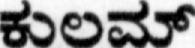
ಕುಲಮ್
